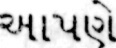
આપણે
